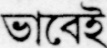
ভাবেই
